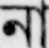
না
